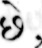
છે,
